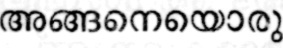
അങ്ങനെയൊരു
